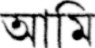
আমি
